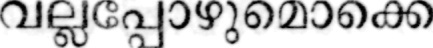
വല്ലപ്പോഴുമൊക്കെ
